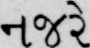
નજરે
